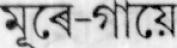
মূৰে-গায়ে
